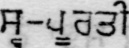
ਸ੍ਵ-ਪੂਰਤੀ
